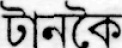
টানকৈ
